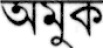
অমুক
